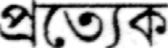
প্রত্যেক
